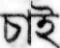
চাই
